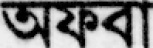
অফবা
